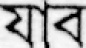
যাব
